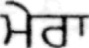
ਮੇਰਾ
